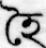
হৈ
